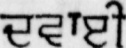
ਦਵਾਈ
